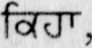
ਕਿਹਾ,
